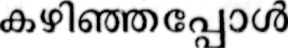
കഴിഞ്ഞപ്പോള്‍
